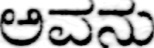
ಅವನು
